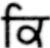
ਕਿ
